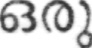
ഒരു
